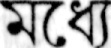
মধ্যে
